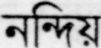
নন্দিয়
